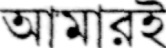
আমারই
